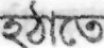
হঠাতে
